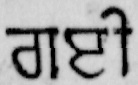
ਗਈ
